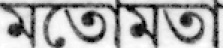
মতোমতা
